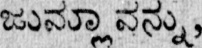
ಜುಮ್ಲಾವನ್ನು,
